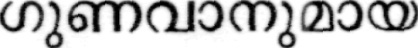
ഗുണവാനുമായ
